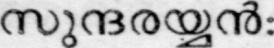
സുന്ദരയ്യന്‍:
